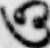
ও
